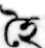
হৈ
